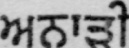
ਅਨਾੜੀ
